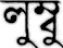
লুম্বু
